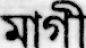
মাগী
